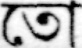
তো
